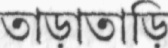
তাড়াতাড়ি
